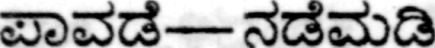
ಪಾವಡೆ-ನಡೆಮಡಿ
